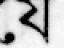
যে
